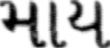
માય
